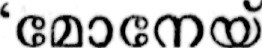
‘മോനേയ്
